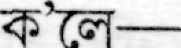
ক'লে-
